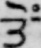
ਤੋਂ
